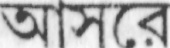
আসরে
